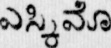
ಎಸ್ಕಿಮೊ
